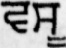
ਵਸੂ
